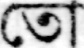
তো
